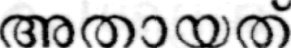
അതായത്
